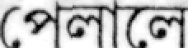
পেলালে
